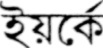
ইয়র্কে
